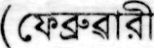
(ফেব্রুৱারী
